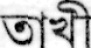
তাখী
